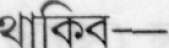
থাকিব-
